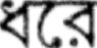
ধরে
